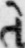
તે
